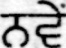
ਨਵੇਂ
